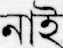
নাই
